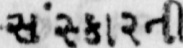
સંસ્કારની
